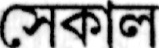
সেকাল
